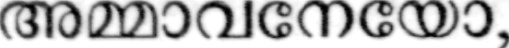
അമ്മാവനേയോ,
